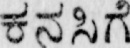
ಕನಸಿಗೆ
